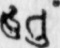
હતું
